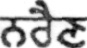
ਨਰੈਣ
